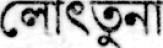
লোৎতুনা
